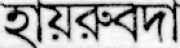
হায়রুবদা
